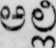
ಅಲ್ಲಿ
